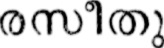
രസീതു
